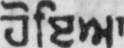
ਹੋਇਆ
